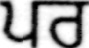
ਪਰ
